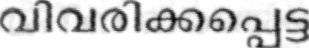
വിവരിക്കപ്പെട്ട
